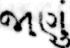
જાણું
